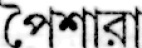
পৈশারা
